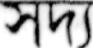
সদ্য
